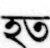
হত
